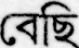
বেছি
